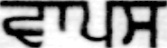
ਵਾਪਸ
